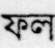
ফল
